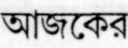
আজকের
